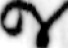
જ
